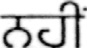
ਨਹੀਂ
